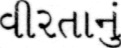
વીરતાનું
